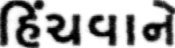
હિંચવાને
